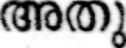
അതു
